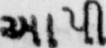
આપી
